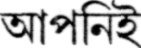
আপনিই
